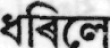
ধৰিলে
